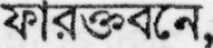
ফারক্তবনে,
